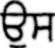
ਉਸ
